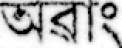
অৱাং
